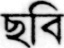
ছবি
